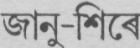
জানু-শিৰে
